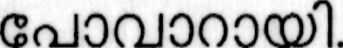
പോവാറായി.
